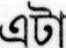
এটা
